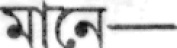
মানে-
